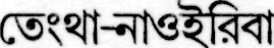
তেংথা-নাওইরিবা
